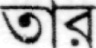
তার
